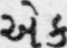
એક
